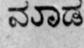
ಮಾಡ
